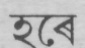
হৰে
